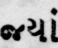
જ્યાં
